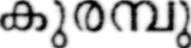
കുരമ്പു
